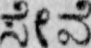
ಸೇವೆ
